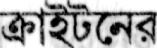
ক্রাইটনের
